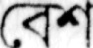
বেশ
